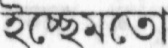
ইচ্ছেমতো
